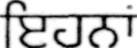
ਇਹਨਾਂ
